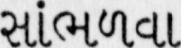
સાંભળવા
